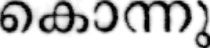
കൊന്നു
